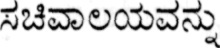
ಸಚಿವಾಲಯವನ್ನು
